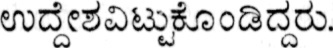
ಉದ್ದೇಶವಿಟ್ಟುಕೊಂಡಿದ್ದರು.
